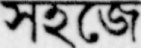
সহজে
